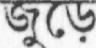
জুড়ে
